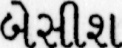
બેસીશ
